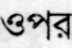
ওপর
